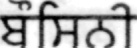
ਬੌਸਿਨੀ
